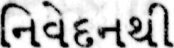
નિવેદનથી
